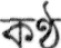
কণ্ঠ
